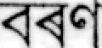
বৰণ
